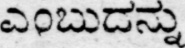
ಎಂಬುದನ್ನು
